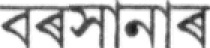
বৰসানাৰ
